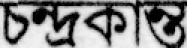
চন্দ্রকান্ত
